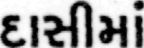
દાસીમાં
